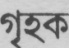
গৃহক
